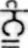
ਨੂੰ
